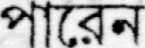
পারেন
